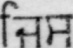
ਜਿਸ
